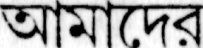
আমাদের
